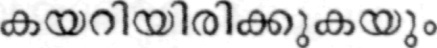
കയറിയിരിക്കുകയും
